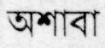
অশাবা
